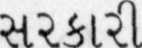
સરકારી
